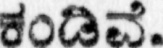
ಕಂಡಿವೆ.
